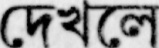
দেখলে
